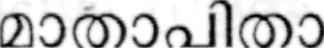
മാതാപിതാ
